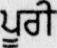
ਪੂਰੀ
